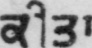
ਕੀਤਾ
